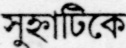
সুহ্নাটিকে
